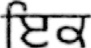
ਇਕ
